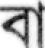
বা
